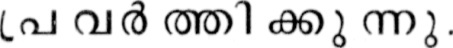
പ്രവര്‍ത്തിക്കുന്നു.
